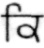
ਕਿ
